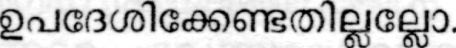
ഉപദേശിക്കേണ്ടതില്ലല്ലോ.
